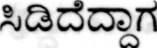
ಸಿಡಿದೆದ್ದಾಗ
